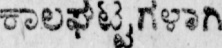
ಕಾಲಘಟ್ಟಗಳಾಗಿ
